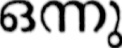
ഒന്നു
